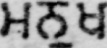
ਮਨੁਖ
